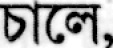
চালে,
